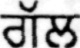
ਗੱਲ
